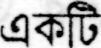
একটি
